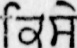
ਕਿਸੇ
